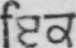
ਇਕ
